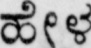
ಹೇಳ
